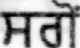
ਸਗੋਂ
